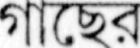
গাছের
